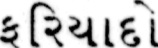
ફરિયાદો
